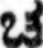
ಚ
